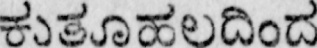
ಕುತೂಹಲದಿಂದ
